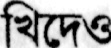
খিদেও
